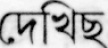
দেখিছ
